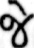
જે
